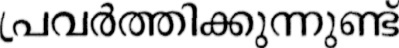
പ്രവര്‍ത്തിക്കുന്നുണ്ട്
